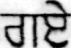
ਗਏ
